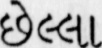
છેલ્લા
